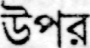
উপর
